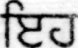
ਇਹ
